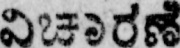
ವಿಚಾರಣೆ
